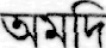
অমদি
